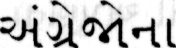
અંગ્રેજોના
